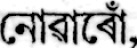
নোৱাৰোঁ,
